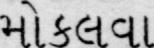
મોકલવા
